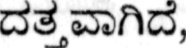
ದತ್ತವಾಗಿದೆ,
